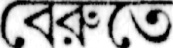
বেরুতে
